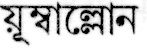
য়ুম্বাল্লোন
